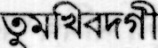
তুমখিবদগী
